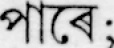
পাৰে;
